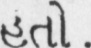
હતો.
